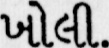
ખોલી.
